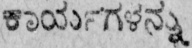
ಕಾರ್ಯಗಳನ್ನು
